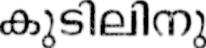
കുടിലിനു
